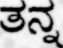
ತನ್ನ
